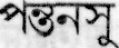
পন্তনসু
